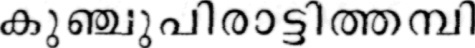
കുഞ്ചുപിരാട്ടിത്തമ്പി
